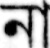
না
